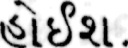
હોઈશ.
